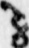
કે
